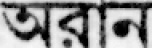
অরান
